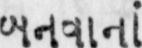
બનવાનાં
